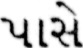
પાસે
